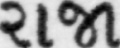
રાજા
